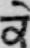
ਕੇ
